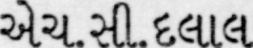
એચ.સી.દલાલ
